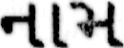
નામ
